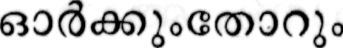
ഓര്‍ക്കുംതോറും
